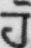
ਹੋ
